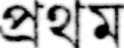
প্রথম
